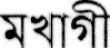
মখাগী
